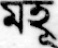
মহূ
